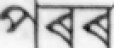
পৰৰ
